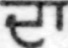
ਦਾ
